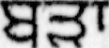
ਬੜਾ
